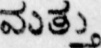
ಮತ್ತು
